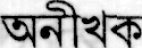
অনীখক
